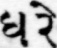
ઘરે
